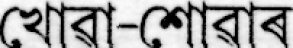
খোৱা-শোৱাৰ
